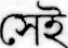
সেই
